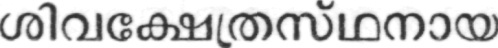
ശിവക്ഷേത്രസ്ഥനായ
